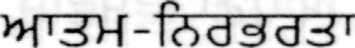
ਆਤਮ-ਨਿਰਭਰਤਾ
